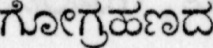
ಗೋಗ್ರಹಣದ
